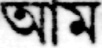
আম
